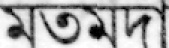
মতমদা
